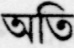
অতি
